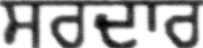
ਸਰਦਾਰ
